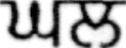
ਘਲ
